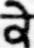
ਕੇ
